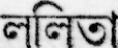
ললিতা
